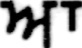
ਆ
